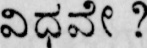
ವಿಧವೇ?
